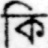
কি
